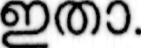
ഇതാ.
